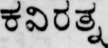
ಕವಿರತ್ನ
